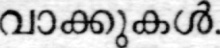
വാക്കുകള്‍.
